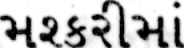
મશ્કરીમાં
